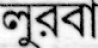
লুরবা
